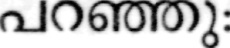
പറഞ്ഞു:
